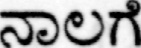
ನಾಲಗೆ
